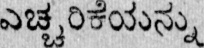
ಎಚ್ಚರಿಕೆಯನ್ನು
